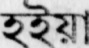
হইয়া
